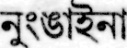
নুংঙাইনা
